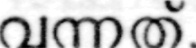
വന്നത്.
